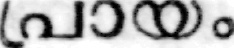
പ്രായം
